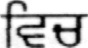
ਵਿਚ
